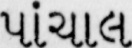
પાંચાલ
